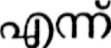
എന്ന്
